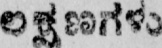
ಲಕ್ಷಣಗಳು
